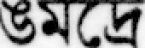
ঙমদ্রে
